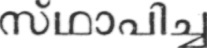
സ്ഥാപിച്ച
